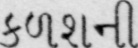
કળશની
